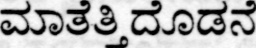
ಮಾತೆತ್ತಿದೊಡನೆ
